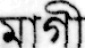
মাগী
